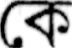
কে
